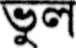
ভুল
